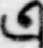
এ
